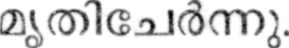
മൃതിചേര്‍ന്നു.
